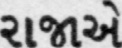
રાજાએ
